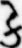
કે
